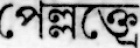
পেল্লক্ত্রে
